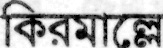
কিরমাল্লে
